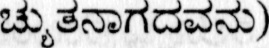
ಚ್ಯುತನಾಗದವನು)
